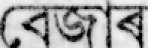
বেজাৰ
